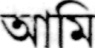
আমি
